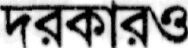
দরকারও
